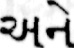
અને
